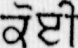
ਕੋਈ
